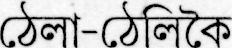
ঠেলা-ঠেলিকৈ
